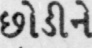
છોડીને
